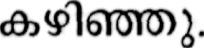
കഴിഞ്ഞു.
